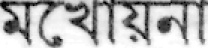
মখোয়না
